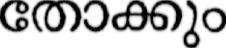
തോക്കും
